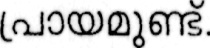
പ്രായമുണ്ട്.
